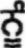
ਨੂੰ
